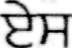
ਏਸ
